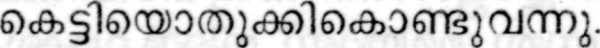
കെട്ടിയൊതുക്കികൊണ്ടുവന്നു.
